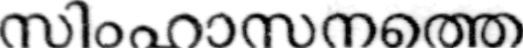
സിംഹാസനത്തെ
